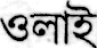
ওলাই
